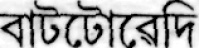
বাটটোৱেদি
